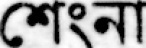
শেংনা
